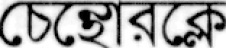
চেন্থোরক্লে
